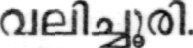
വലിച്ചൂരി.
